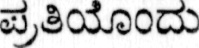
ಪ್ರತಿಯೊಂದು
